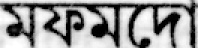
মফমদো
